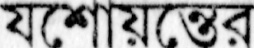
যশোয়ন্তের
